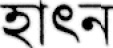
হাৎন
